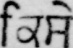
ਕਿਸੇ
